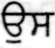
ਉਸ
